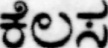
ಕೆಲಸ
